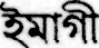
ইমাগী
